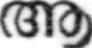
ആ
